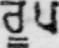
ਰੂਪ
